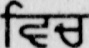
ਵਿਚ
